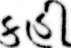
કહી
